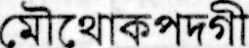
মৌথোকপদগী
